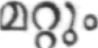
മറ്റും
